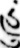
હું
